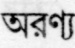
অরণ্য
